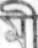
মী
